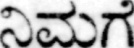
ನಿಮಗೆ
